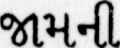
જામની
